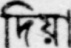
দিয়া
